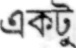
একটু
